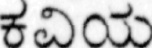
ಕವಿಯ
